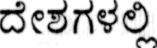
ದೇಶಗಳಲ್ಲಿ
